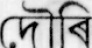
দৌৰি
